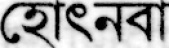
হোৎনবা
